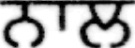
ਨਾਲ
